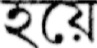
হয়ে
